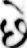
છે
